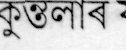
কুন্তলাৰ
